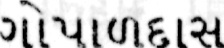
ગોપાળદાસ
